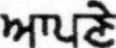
ਆਪਣੇ
